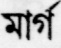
মার্গ
